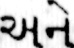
અને
